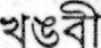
খঙবী
